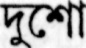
দুশো
